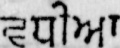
ਵਧੀਆ
